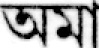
অমা
